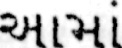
આમાં
